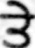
ਤੇ
